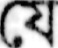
যে
